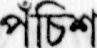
পঁচিশ
